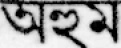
অহুম
